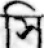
সি
